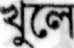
খুলে
